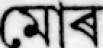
মোৰ
